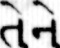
તેને
